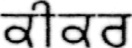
ਕੀਕਰ
